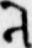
ને
